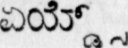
ಏಯ್ಡ್ಸ್
